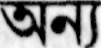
অন্য
